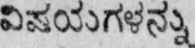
ವಿಷಯಗಳನ್ನು
